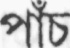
পাঁচ
